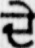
ਦੇ
